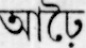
আঢ়ৈ
